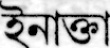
ইনাক্তা
